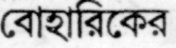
বোহারিকের
